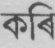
কৰি
